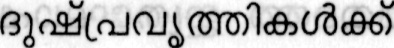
ദുഷ്പ്രവൃത്തികള്‍ക്ക്
